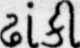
ઢાંકી
